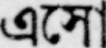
এসো
